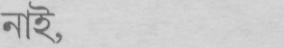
নাই,
